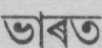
ভাৰত
